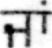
ਜਾਂ
